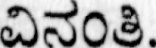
ವಿನಂತಿ.
